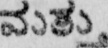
ಮತ್ತು
